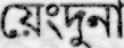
য়েংদুনা
